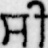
ਸੀ
